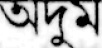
অদুম
